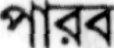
পারব
